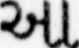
આ
